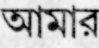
আমার
